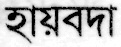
হায়বদা
